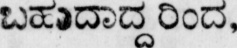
ಬಹುದಾದ್ದರಿಂದ,
